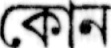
কোন
